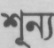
শূন্য
